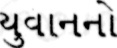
યુવાનનો
